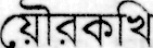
য়ৌরকখি
